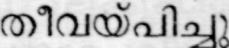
തീവയ്പിച്ചു.
